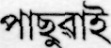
পাছুৱাই
